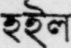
হইল
